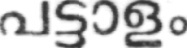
പട്ടാളം
